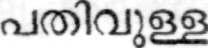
പതിവുള്ള
